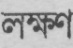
লক্ষণ
